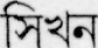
সিখন
